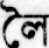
লৈ
